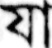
যা
